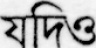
যদিও
